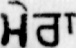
ਮੇਰਾ
